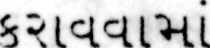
કરાવવામાં
